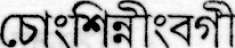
চোংশিন্নীংবগী
